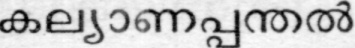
കല്യാണപ്പന്തല്‍
